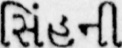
સિંહની
